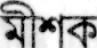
মীশক
